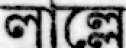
লাল্লে
